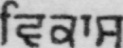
ਵਿਕਾਸ
